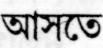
আসতে
